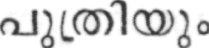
പുത്രിയും
